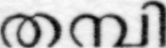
തമ്പി
